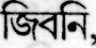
জিবনি,
